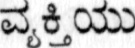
“ವ್ಯಕ್ತಿಯು
